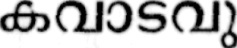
കവാടവു
